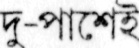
দু-পাশেই
